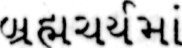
બ્રહ્મચર્યમાં
